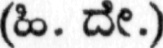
(ಹಿ.ದೇ.)
